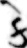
કે
